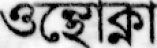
ওন্থোক্ন
